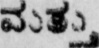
ಮತ್ತು
